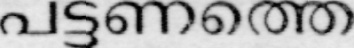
പട്ടണത്തെ
